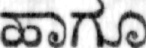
ಹಾಗೂ
